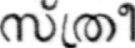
സ്ത്രീ
